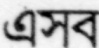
এসব
